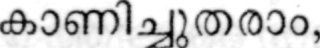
കാണിച്ചുതരാം,
